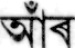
আঁৰ
